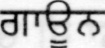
ਗਾਊਨ
